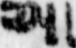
આ
